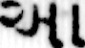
આ
